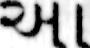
આ
